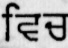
ਵਿਚ
